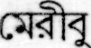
মেরীবু
